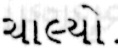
ચાલ્યો.
